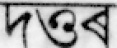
দত্তৰ
